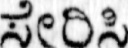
ಸೇರಿಸಿ
